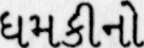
ધમકીનો
